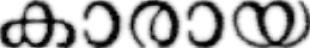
കാരായ
